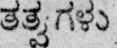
ತತ್ವಗಳು
